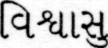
વિશ્વાસુ
